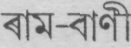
ৰাম-বাণী
